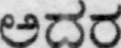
ಅದರ
